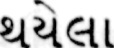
થયેલા
